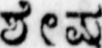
ಶೇಷ
